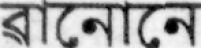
ৱানোনে
